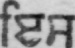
ਇਸ
